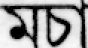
মচা
